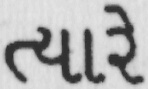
ત્યારે
